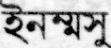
ইনম্মসু
